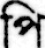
পি
